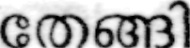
തേങ്ങി
